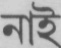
নাই
